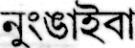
নুংঙাইবা
